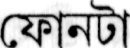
ফোনটা
